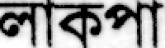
লাকপা
